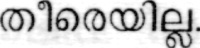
തീരെയില്ല.
